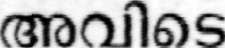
അവിടെ
